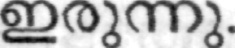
ഇരുന്നു.
